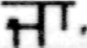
ਜਾ
